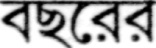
বছরের
